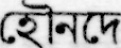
হৌনদে
